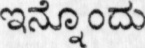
ಇನ್ನೊಂದು
